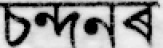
চন্দনৰ
